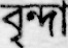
বৃন্দা
